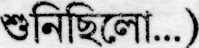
শুনিছিলো....)
